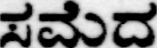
ಸಮೆದ
